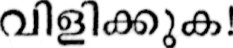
വിളിക്കുക!
